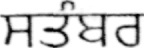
ਸਤੰਬਰ
